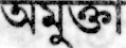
অমুক্তা
